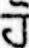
ਹੋ
